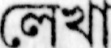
লেখা
